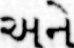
અને
